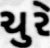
ચુરે
